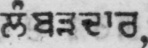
ਲੰਬੜਦਾਰ,
